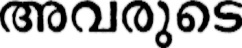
അവരുടെ
